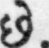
છે.
